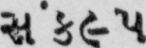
સંકલ્પ
